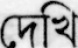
দেখি
